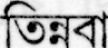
তিন্নবা
